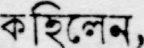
কহিলেন,
